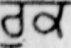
ਰੁਕ
